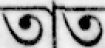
তাত
